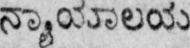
ನ್ಯಾಯಾಲಯ
